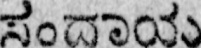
ಸಂದಾಯ
